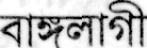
বাঙ্গলাগী
